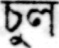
চুল
